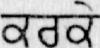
ਕਰਕੇ
